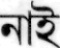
নাই
